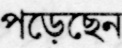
পড়েছেন
